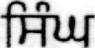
ਸਿੰਘ
